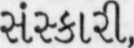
સંસ્કારી,
